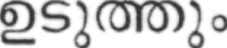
ഉടുത്തും
